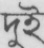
দুই
